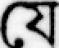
যে
